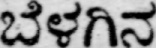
ಬೆಳಗಿನ
